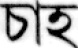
চাহ
